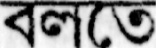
বলতে
